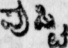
ಪುಷ್ಟಿ
